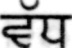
ਵੱਧ
